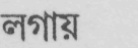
লগায়
